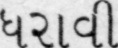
ધરાવી
